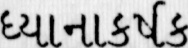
ધ્યાનાકર્ષક
